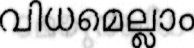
വിധമെല്ലാം
